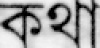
কথা
